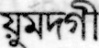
য়ুমদগী
